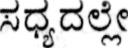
ಸಧ್ಯದಲ್ಲೇ
